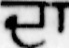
ਦਾ
